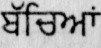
ਬੱਚਿਆਂ
